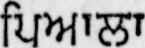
ਪਿਆਲਾ
